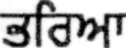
ਭਰਿਆ
